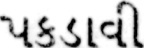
પકડાવી
